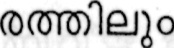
രത്തിലും
